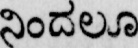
ನಿಂದಲೂ
